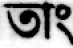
তাং
